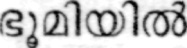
ഭൂമിയില്‍
